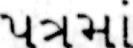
પત્રમાં
